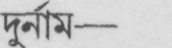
দুৰ্নাম-
